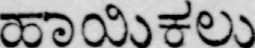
ಹಾಯಿಕಲು
